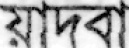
য়াদবা
